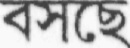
বসছে
